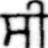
ਸੀ
